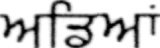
ਅਡਿਆਂ
